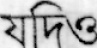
যদিও
